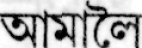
আমালৈ
